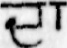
ਦਾ
